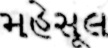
મહેસૂલ
